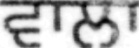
ਵਾਲਾ
